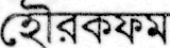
হৌরকফম
